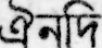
ঐনদি
